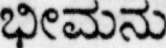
ಭೀಮನು
